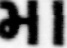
મા
